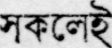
সকলেই
